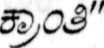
ಕ್ರಾಂತಿ”
